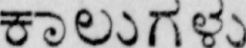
ಕಾಲುಗಳು
